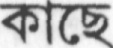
কাছে
